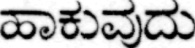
ಹಾಕುವುದು
